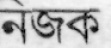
নিজক
